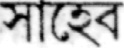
সাহেব
